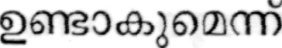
ഉണ്ടാകുമെന്ന്
